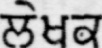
ਲੇਖਕ
